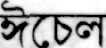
ঈচেল
